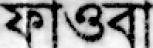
ফাওবা
